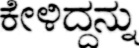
ಕೇಳಿದ್ದನ್ನು
